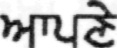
ਆਪਣੇ
